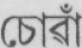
চোৱাঁ
